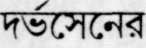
দর্ভসেনের
